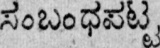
ಸಂಬಂಧಪಟ್ಟ
